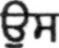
ਉਸ
